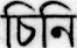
চিনি
